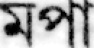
মপা
